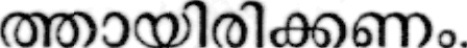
ത്തായിരിക്കണം.
